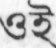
ওই
